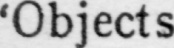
'Objects
